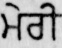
ਮੇਰੀ
